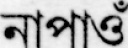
নাপাওঁ
